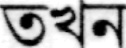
তখন
